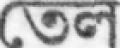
তেল
